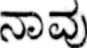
ನಾವು
